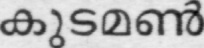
കുടമണ്‍
